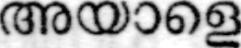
അയാളെ
